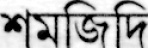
শমজিদি
